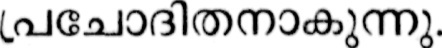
പ്രചോദിതനാകുന്നു.
